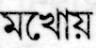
মখোয়
